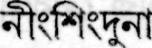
নীংশিংদুনা
